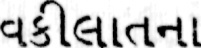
વકીલાતના
